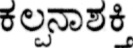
ಕಲ್ಪನಾಶಕ್ತಿ
